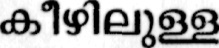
കീഴിലുള്ള
